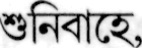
শুনিবাহে,
